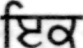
ਇਕ
